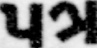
પત્ર
